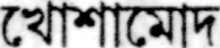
খোশামোদ
